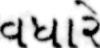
વધારે
